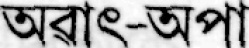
অৱাৎ-অপা
